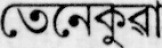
তেনেকুৱা
